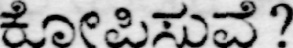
ಕೋಪಿಸುವೆ?
